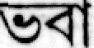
ভবা
